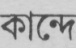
কান্দে
